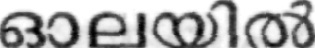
ഓലയില്‍
